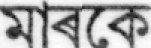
মাৰকে
